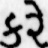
કરે
